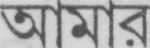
আমার
